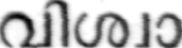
വിശ്വാ
